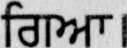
ਗਿਆ।
